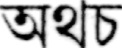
অথচ
